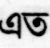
এত
